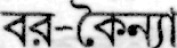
বর-কৈন্যা
